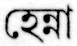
হেন্না
